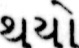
થયો
